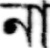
না
